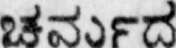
ಚರ್ಮದ
